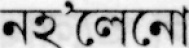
নহ'লেনো
